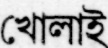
খোলাই
